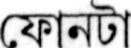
ফোনটা
